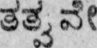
ತತ್ವವೇ
